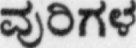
ವುರಿಗಳ
